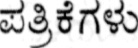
ಪತ್ರಿಕೆಗಳು
